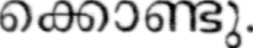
ക്കൊണ്ടു.
